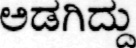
ಅಡಗಿದ್ದು
